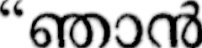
"ഞാന്‍
